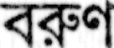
বরুণ
